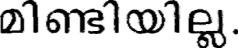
മിണ്ടിയില്ല.
